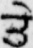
ਤੇ
